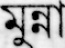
মুন্না
